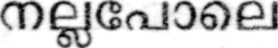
നല്ലപോലെ
